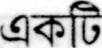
একটি
